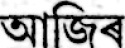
আজিৰ
